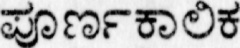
ಪೂರ್ಣಕಾಲಿಕ
